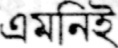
এমনিই
